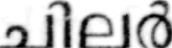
ചിലര്‍
